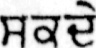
ਸਕਦੇ
